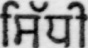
ਸਿੱਧੀ
